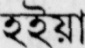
হইয়া
